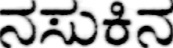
ನಸುಕಿನ
